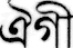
ঐগী
